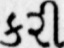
કરી
